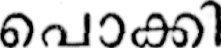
പൊക്കി
